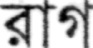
রাগ
